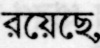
রয়েছে,
